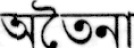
অতৈনা
